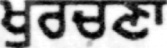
ਖੁਰਚਣਾ
